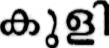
കുളി
